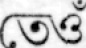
তেওঁ
